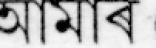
আমাৰ
